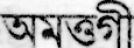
অমত্তগী
